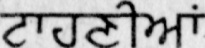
ਟਾਹਣੀਆਂ
